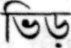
ভিড়
